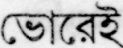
ভোরেই
